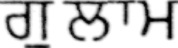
ਗੁਲਾਮ
